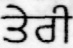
ਤੇਰੀ
